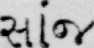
સાંજ
